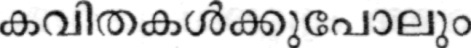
കവിതകള്‍ക്കുപോലും
